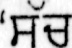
'ਸੱਚ
